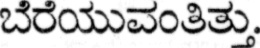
ಬೆರೆಯುವಂತಿತ್ತು.
